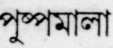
পুষ্পমালা
